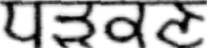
ਧੜਕਣ
